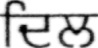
ਦਿਲ
